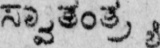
ಸ್ವಾತಂತ್ರ್ಯ
